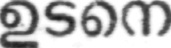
ഉടനെ
